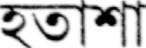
হতাশা
